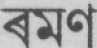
ৰমণ
